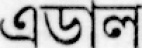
এডাল
